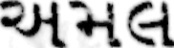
અમલ
